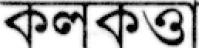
কলকত্তা
